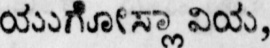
ಯುಗೋಸ್ಲಾವಿಯ,
